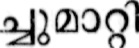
ച്ചുമാറ്റി
